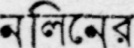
নলিনের
